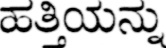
ಹತ್ತಿಯನ್ನು
